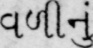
વળીનું
